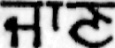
ਜਾਣ
